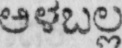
ಅಳಬಲ್ಲ
